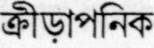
ক্রীড়াপনিক
